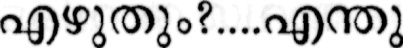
എഴുതും?....എന്തു
